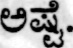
ಅಷ್ಟೆ.
